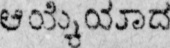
ಆಯ್ಕೆಯಾ
